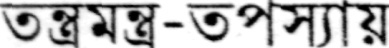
তন্ত্রমন্ত্র-তপস্যায়
